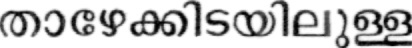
താഴേക്കിടയിലുള്ള
